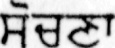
ਸੋਚਣਾ
